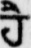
ਹੈ
